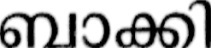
ബാക്കി
